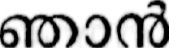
ഞാന്‍
